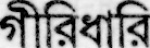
গীরিধারি
